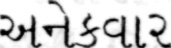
અનેકવાર
